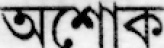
অশোক
